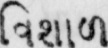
વિશાળ
